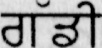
ਗੱਡੀ
